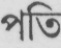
পতি
